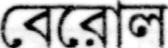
বেরোল
